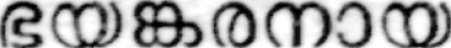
ഭയങ്കരനായ
